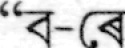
"ব-ৰে
